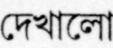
দেখালো
